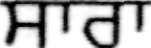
ਸਾਰਾ
